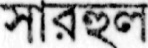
সারহুল
